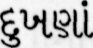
દુખણાં
